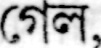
গেল,
